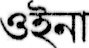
ওইনা
